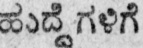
ಹುದ್ದೆಗಳಿಗೆ
